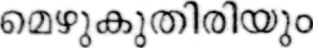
മെഴുകുതിരിയും
